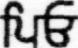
ਪਿਓ
